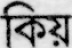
কিয়
